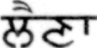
ਲੈਣਾ
